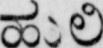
ಹುಲಿ
